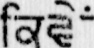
ਕਿਵੇਂ
